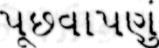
પૂછવાપણું
